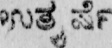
ಉತ್ಕರ್ಷೆ
